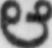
ಆ
